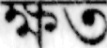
ক্ষত
